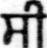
ਸੀ
